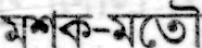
মশক-মতৌ
